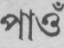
পাওঁ
